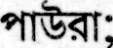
পাউরা;
